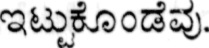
ಇಟ್ಟುಕೊಂಡೆವು.
